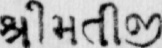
શ્રીમતીજી
